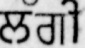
ਲੱਗੀ
